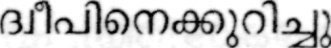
ദ്വീപിനെക്കുറിച്ചു
